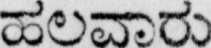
ಹಲವಾರು
